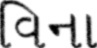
વિના
